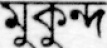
মুকুন্দ
